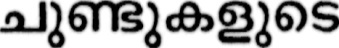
ചുണ്ടുകളുടെ
